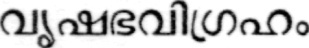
വൃഷഭവിഗ്രഹം
